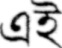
এই
